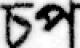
চপ
